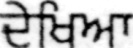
ਦੇਖਿਆ
